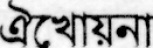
ঐখোয়না
